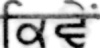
ਕਿਵੇਂ
